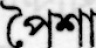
পৈশা
